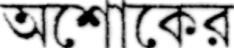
অশোকের
